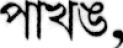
পাখঙ,
